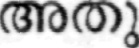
അതു
